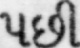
પછી
